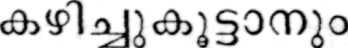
കഴിച്ചുകൂട്ടാനും
